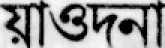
য়াওদনা
